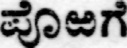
ಪೊಱಗೆ
